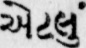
એટલું
